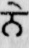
ਨੇ
